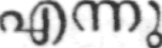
എന്നു
